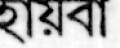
হায়বা
